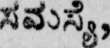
ಸಮಸ್ಯೆ,
